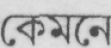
কেমনে
